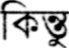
কিন্তু
